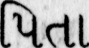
પિતા
